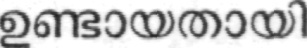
ഉണ്ടായതായി
